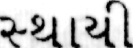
સ્થાયી
